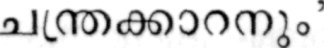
ചന്ത്രക്കാറനും'
